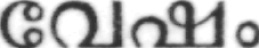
വേഷം
